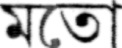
মতো
